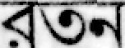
রতন
